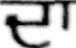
ਦਾ
